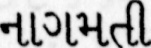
નાગમતી
